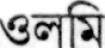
ওলমি
